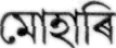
মোহাৰি
